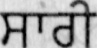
ਸਾਰੀ
